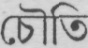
চৌতি
